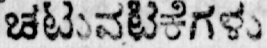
ಚಟುವಟಿಕೆಗಳು
